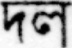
দল
